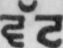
ਵੱਟ
